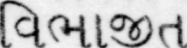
વિભાજીત
